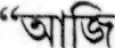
"আজি
